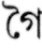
গৈ
